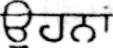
ਉਹਨਾਂ
